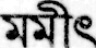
মমীৎ
